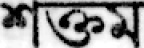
শক্তম
